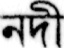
নদী
